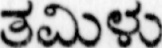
ತಮಿಳು
